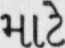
માટે
